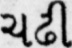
ચઢી
